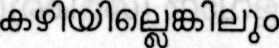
കഴിയില്ലെങ്കിലും
